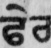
ਫੇਰ
